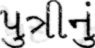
પુત્રીનું
